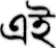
এই
